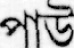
পাউ
